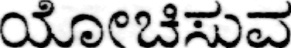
ಯೋಚಿಸುವ
